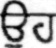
ਉਹ
